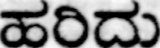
ಹರಿದು
